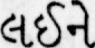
લઈને
